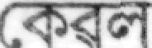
কেৱল
